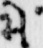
મેં
